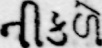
નીકળે
